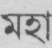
মহা
